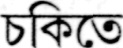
চকিতে
